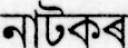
নাটকৰ
